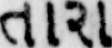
તારા
